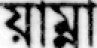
য়াম্না
